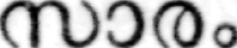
സാരം
